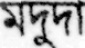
মদুদা
